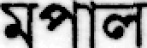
মপাল
